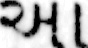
આ
